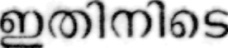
ഇതിനിടെ
